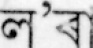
ল'ৰা
